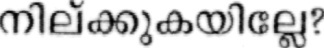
നില്ക്കുകയില്ലേ?
